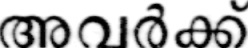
അവര്‍ക്ക്
